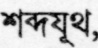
শব্দযূথ,
